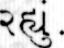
રહ્યું.
